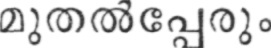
മുതല്‍പ്പേരും
